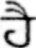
ਹੈ
